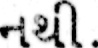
નથી.
